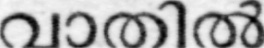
വാതില്‍
